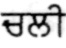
ਚਲੀ
